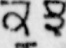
ਕੁਝ
